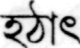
হঠাৎ
